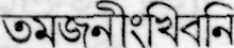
তমজনীংখিবনি
